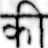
की
